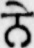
ਨੇ
